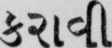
કરાવી
